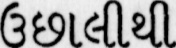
ઉછાલીથી
